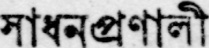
সাধনপ্রণালী
